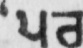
'ਪਰ
